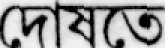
দোষতে
